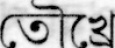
তৌখ্রে
